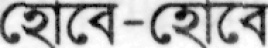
হোবে-হোবৈ
